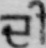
ਦੀ
